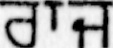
ਰਾਜ
